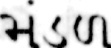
મંડળ
